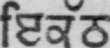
ਇਕੱਠ
